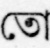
তো
